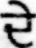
ਦੇ
